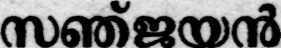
സഞ്ജയന്‍
